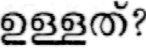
ഉള്ളത്?
